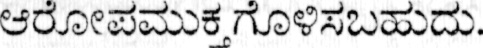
ಆರೋಪಮುಕ್ತಗೊಳಿಸಬಹುದು.
